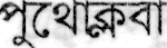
পুথোক্লবা
